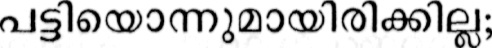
പട്ടിയൊന്നുമായിരിക്കില്ല;
